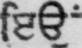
ਇਉਂ
